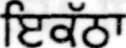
ਇਕੱਠਾ
